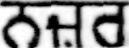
ਨਜ਼ਰ
